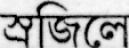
স্রজিলে
